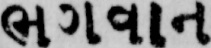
ભગવાન
